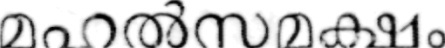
മഹല്‍സമക്ഷം
